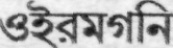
ওইরমগনি
